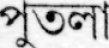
পুতলা
